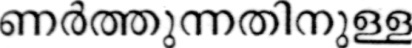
ണര്‍ത്തുന്നതിനുള്ള
